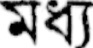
মধ্য
